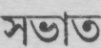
সভাত
